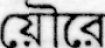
য়ৌরে
